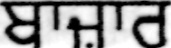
ਬਾਜ਼ਾਰ
